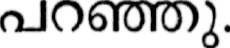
പറഞ്ഞു.
